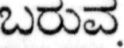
ಬರುವ
